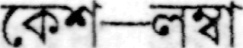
কেশ—লম্বা
